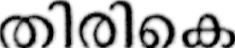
തിരികെ
